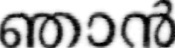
ഞാന്‍
